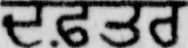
ਦਫ਼ਤਰ
